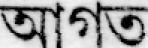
আগত
